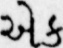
એક
